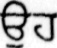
ਉਹ
